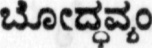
ಬೋದ್ಧವ್ಯಂ
